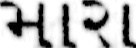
મારા
